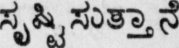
ಸೃಷ್ಟಿಸುತ್ತಾನೆ
